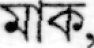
মাক,
